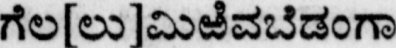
ಗೆಲ[ಲು]ಮಿಱವಬೆಡಂಗಾ
